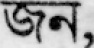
জন,
